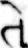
તે
